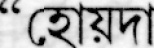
“হোয়দা
